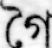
গৈ
